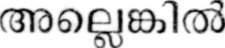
അല്ലെങ്കില്‍
